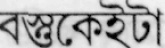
বস্তুকেইটা
